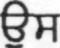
ਉਸ
